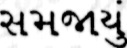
સમજાયું
